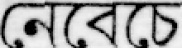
নেবেচে
